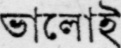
ভালোই
